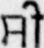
ਸੀ
